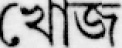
খোজ
